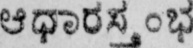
ಆಧಾರಸ್ತಂಭ
